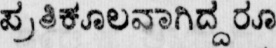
ಪ್ರತಿಕೂಲವಾಗಿದ್ದರೂ
